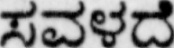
ಸವಳದೆ
